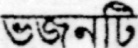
ভজনটি
